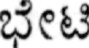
ಭೇಟಿ
